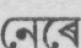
নেৰে
